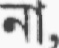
না,
